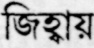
জিহ্বায়
